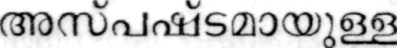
അസ്പഷ്ടമായുള്ള
